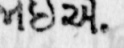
જોઈએ.
